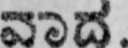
ವಾದ.
